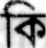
কি
